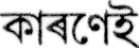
কাৰণেই
